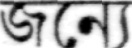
জন্যে
